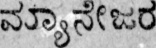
ಮ್ಯಾನೇಜರ
